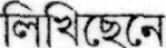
লিখিছেনে
